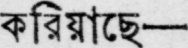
করিয়াছে—
